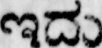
ಇದು
